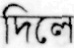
দিলে
